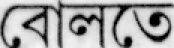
বোলতে
